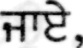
ਜਾਏ,
